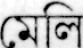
মেলি
